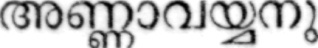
അണ്ണാവയ്യനു
